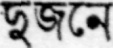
দুজনে
